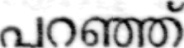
പറഞ്ഞ്
